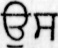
ਉਸ
